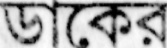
ডাকের
